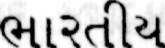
ભારતીય
